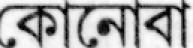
কোনোবা
